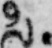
ಸಿ.
